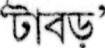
‘টাবড়'
